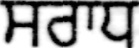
ਸਰਾਧ
